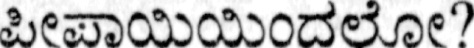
ಪೀಪಾಯಿಯಿಂದಲೋ?
